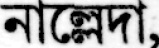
নাল্লেদা,
